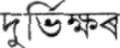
দুর্ভিক্ষৰ
